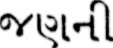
જણની
